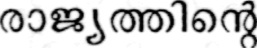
രാജ്യത്തിന്റെ
